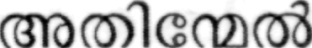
അതിന്മേല്‍
